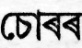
চোৰৰ
